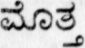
ಮೊತ್ತ
